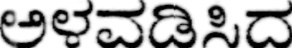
ಅಳವಡಿಸಿದ
